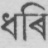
ধৰি
